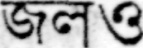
জলও
